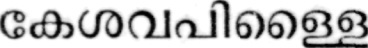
കേശവപിള്ളൈ
